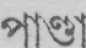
পাণ্ডা
